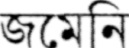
জমেনি
